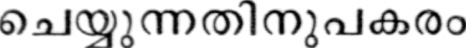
ചെയ്യുന്നതിനുപകരം
